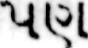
પણ
